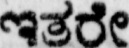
ಇತರೇ
